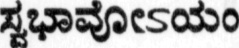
ಸ್ವಭಾವೋsಯಂ
